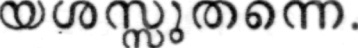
യശസ്സുതന്നെ.
